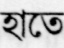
হাতে
